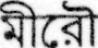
মীরৌ
